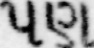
પણ
